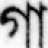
গা
